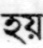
হয়
